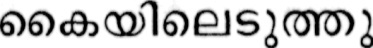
കൈയിലെടുത്തു
